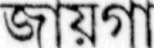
জায়গা
